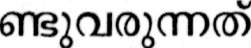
ണ്ടുവരുന്നത്
